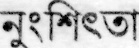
নুংশিৎতা
